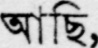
আছি,
